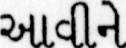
આવીને
